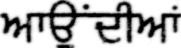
ਆਉਂਦੀਆਂ
